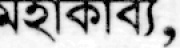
মহাকাব্য,
